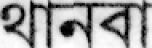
থানবা
